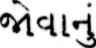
જોવાનું
